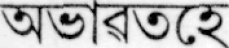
অভাৱতহে
